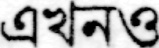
এখনও
